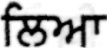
ਲਿਆ
